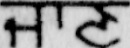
ਜਾਣ
